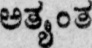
ಅತ್ಯಂತ
